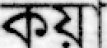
কয়া
